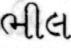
ભીલ
